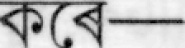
কৰে-
